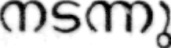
നടന്നു
